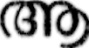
ആ
